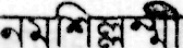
নমশিল্লম্মী
